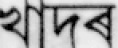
খাদৰ
